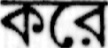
করে
